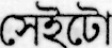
সেইটো
